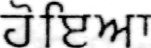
ਹੋਇਆ
